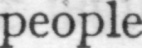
people
